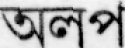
অলপ
